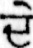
ਦੇ
